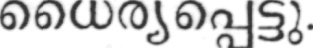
ധൈര്യപ്പെട്ടു.
